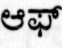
ಆಫ್
